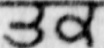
ਤਕ
